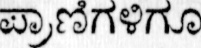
ಪ್ರಾಣಿಗಳಿಗೂ
